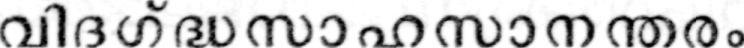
വിദഗ്ദ്ധസാഹസാനന്തരം
